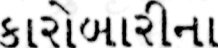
કારોબારીના
